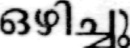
ഒഴിച്ചു
